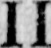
II
